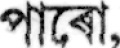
পাৰো,
